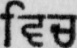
ਵਿਚ
